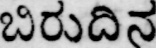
ಬಿರುದಿನ
